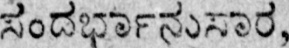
ಸಂದರ್ಭಾನುಸಾರ,
